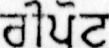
ਰੀਪੋਟ
